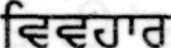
ਵਿਵਹਾਰ
